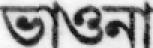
ভাওনা
